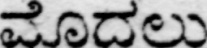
ಮೊದಲು
